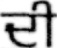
ਦੀ
